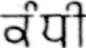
ਕੰਧੀ
